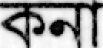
কনা
